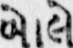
બોલે
